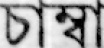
চাম্বা
